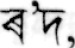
ৰ'দ,
